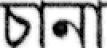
চানা
